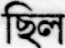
ছিল
